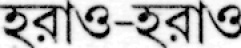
হরাও-হরাও
